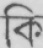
কি
